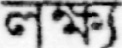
লক্ষ্য
